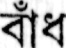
বাঁধ
